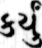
કર્યું
